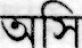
অসি
